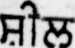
ਸ਼ੀਲ
